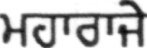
ਮਹਾਰਾਜੇ
